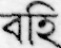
বহি
